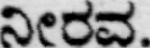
ನೀರವ.
